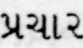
પ્રચાર
